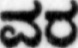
ವರ
